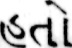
હતો
